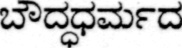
ಬೌದ್ಧಧರ್ಮದ
